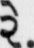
રે.
